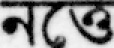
নত্তে
